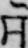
ਸੋ
